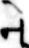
ને
